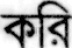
করি
